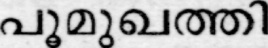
പൂമുഖത്തി
